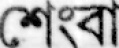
শেংবা
